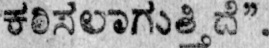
ಕರಿಸಲಾಗುತ್ತಿದೆ”.
